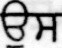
ਉਸ
